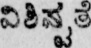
ವಿಶಿಷ್ಟತೆ
